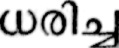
ധരിച്ച
